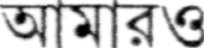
আমারও
